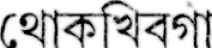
থোকখিবগা
